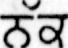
ਨੱਕ
